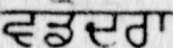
ਵਡੋਦਰਾ
